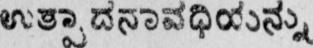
ಉತ್ಪಾದನಾವಧಿಯನ್ನು
